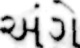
અંગે
